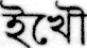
ইখৌ
